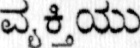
ವ್ಯಕ್ತಿಯು
